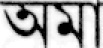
অমা
